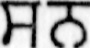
ਸਨ
